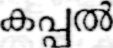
കപ്പല്‍
